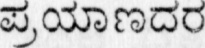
ಪ್ರಯಾಣದರ
